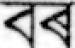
বৰ
